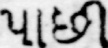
પાછી
